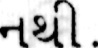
નથી.
